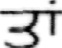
ਤਾਂ
